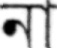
না
